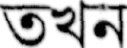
তখন
